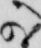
જે
